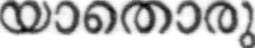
യാതൊരു
